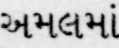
અમલમાં
